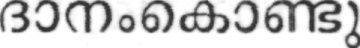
ദാനംകൊണ്ടു
